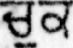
ਚੁਕ
